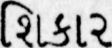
શિકાર
